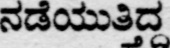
ನಡೆಯುತ್ತಿದ್ದ
